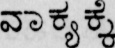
ವಾಕ್ಯಕ್ಕೆ
